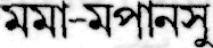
মমা-মপানসু
